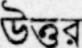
উত্তর
